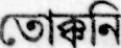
তোক্কনি
